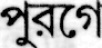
পুরগে
